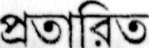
প্রতারিত
